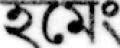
হমেং
